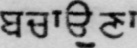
ਬਚਾਉਣਾ
